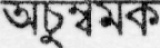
অচুম্বমক
